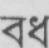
বধ
